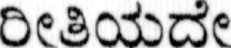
ರೀತಿಯದೇ
